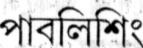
পাবলিশিং
